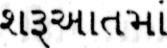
શરૂઆતમાં
